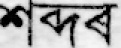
শব্দৰ
